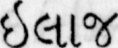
ઇલાજ
